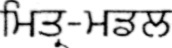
ਮਿਤ੍ਰ-ਮਡਲ
